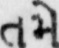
તમે
